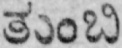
ತುಂಬಿ
